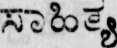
ಸಾಹಿತ್ಯ
